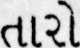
તારો
